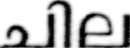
ചില
